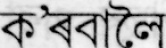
ক'ৰবালৈ
